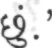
છું.'
